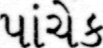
પાંચેક
